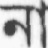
না
